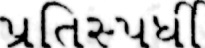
પ્રતિસ્પર્ધી
